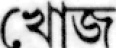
খোজ
